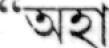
"অহা
